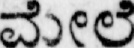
ಮೇಲೆ
